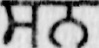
ਸਨ
